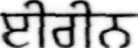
ਈਰੀਨ
